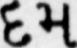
દમ
